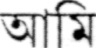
আমি
